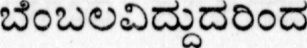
ಬೆಂಬಲವಿದ್ದುದರಿಂದ
